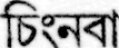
চিংনবা
